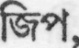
জিপ,
